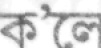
ক'লে
